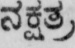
ನಕ್ಷತ್ರ
